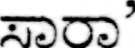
ಸಾರಾ'
